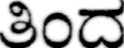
ತಿಂದ
